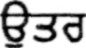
ਉਤਰ
